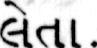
લેતા.
